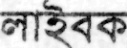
লাইব
